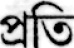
প্রতি
